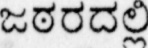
ಜಠರದಲ್ಲಿ
